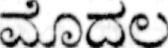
ಮೊದಲ
